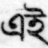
এই
